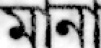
মানা
